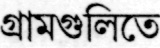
গ্রামগুলিতে
